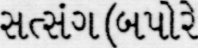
-સત્સંગ(બપોરે
